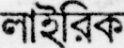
লাইরিক
